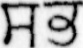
ਸਭ
